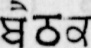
ਬੈਠਕ
